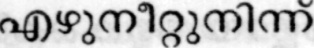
എഴുനീറ്റുനിന്ന്
